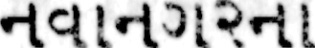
નવાનગરના
